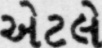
એટલે
